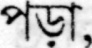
পড়া,
